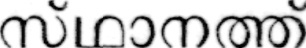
സ്ഥാനത്ത്
